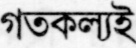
গতকল্যই
